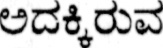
ಅದಕ್ಕಿರುವ
